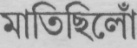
মাতিছিলোঁ
